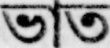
ভাত
